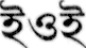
ইওই
